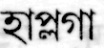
হাপ্লগা
